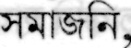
সমাজনি
